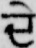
ਦੇ
